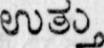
ಉತ್ತು
